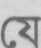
যে
